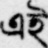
এই
